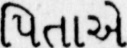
પિતાએ
